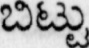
ಬಿಟ್ಟು
